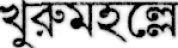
খুরুমহল্লে
